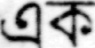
এক
